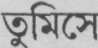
তুমিসে
